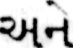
અને
